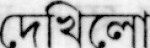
দেখিলো
